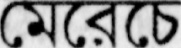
মেরেচে
